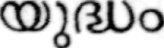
യുദ്ധം
